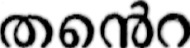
തന്റെ
